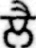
ਲੈ
